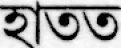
হাতত
